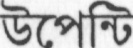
উপেন্টি
